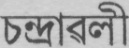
চন্দ্ৰাৱলী
